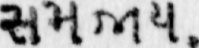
સમાજય.
